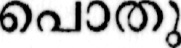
പൊതു
